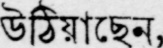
উঠিয়াছেন,
